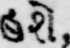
હશે,
